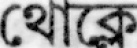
থোক্লে
